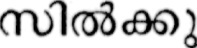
സില്‍ക്കു
